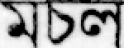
মচল
